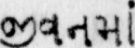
જીવનમાં
